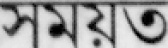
সময়ত
